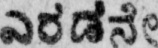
ಎರಡನೇ
